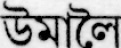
উমালৈ
